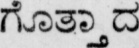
ಗೊತ್ತಾದ
